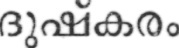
ദുഷ്കരം
